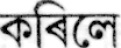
কৰিলে
